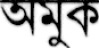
অমুক
